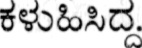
ಕಳುಹಿಸಿದ್ದ.
